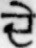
ਦੇ
